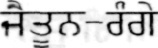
ਜੈਤੂਨ-ਰੰਗੇ
